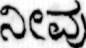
ನೀವು
